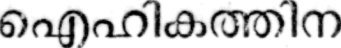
ഐഹികത്തിന
